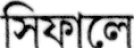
সিফালে
